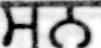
ਸਨ
